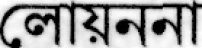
লোয়ননা
